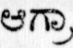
ಆಗ್ರಾ
